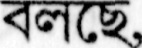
বলছে,
